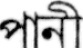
পানী
